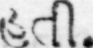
હતી.
